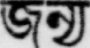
জন্য
